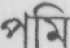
পমি
